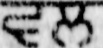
ਵਲ
